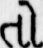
તો
